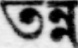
তন্ন
